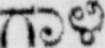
ಗಾಳಿ
